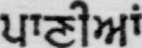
ਪਾਣੀਆਂ
